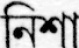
নিশা
